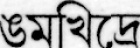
ঙমখিদ্রে
